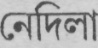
নেদিলা
